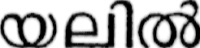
യലില്‍
